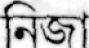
নিজা
